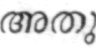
അതു
